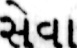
સેવા
